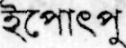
ইপোৎপু
